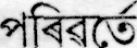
পৰিৱর্তে
